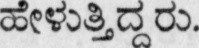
ಹೇಳುತ್ತಿದ್ದರು.
